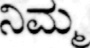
ನಿಮ್ಮ
